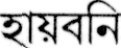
হায়বনি
